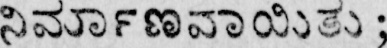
ನಿರ್ಮಾಣವಾಯಿತು;
